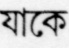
যাকে
